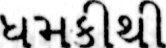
ધમકીથી
